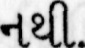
નથી.
